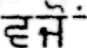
ਵਜੋਂ
